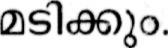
മടിക്കും.
